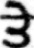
ਤੇ
